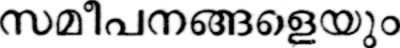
സമീപനങ്ങളെയും
